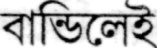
বান্ডিলেই
